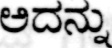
ಅದನ್ನು
